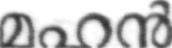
മഹന്‍
